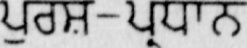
ਪੁਰਸ਼-ਪ੍ਰਧਾਨ
